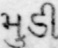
મુડી
